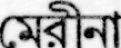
মেরীনা
